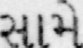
સામે
